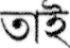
তাই
